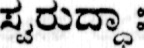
ಸ್ವರುದ್ಧಾಃ
